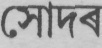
সোদৰ
